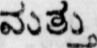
ಮತ್ತು
